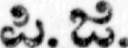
ಪಿ.ಜಿ.
